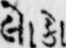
લોકો
